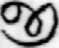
જી
